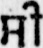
ਸੀ
